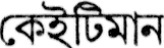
কেইটিমান
